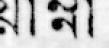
য়াম্না
